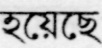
হয়েছে
